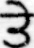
ਤੇ
